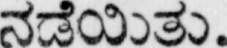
ನಡೆಯಿತು.
